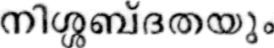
നിശ്ശബ്ദതയും
